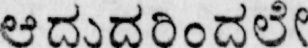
ಆದುದರಿಂದಲೇ
